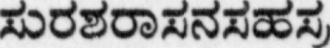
ಸುರಶರಾಸನಸಹಸ್ರ
